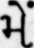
મેં
